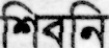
শিবনি
